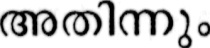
അതിന്നും
